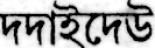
দদাইদেউ
